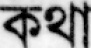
কথা
